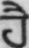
ਹੈ
